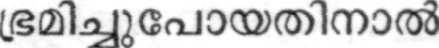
ഭ്രമിച്ചുപോയതിനാല്‍
